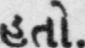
હતો.
